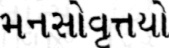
મનસોવૃત્તયો
